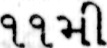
૧૧મી
